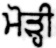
ਮੋੜ੍ਹੀ
